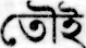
তৌই
